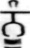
ਨੂੰ
